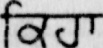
ਕਿਹਾ
